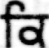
ਕਿ
